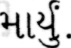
માર્યું.
